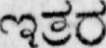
ಇತರ
